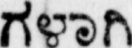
ಗಳಾಗಿ
